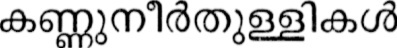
കണ്ണുനീര്‍തുള്ളികള്‍
